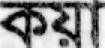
কয়া
